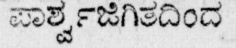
ಪಾರ್ಶ್ವಜಿಗಿತದಿಂದ
